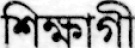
শিক্ষাগী
